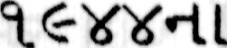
૧૯૪૪ના
